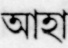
আহা
